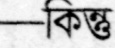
–কিন্তু
